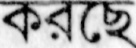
করছে
